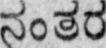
ನಂತರ
